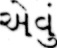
એવું
